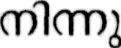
നിന്നു
